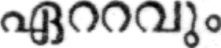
ഏററവും
